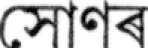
সোণৰ
